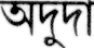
অদুদা
